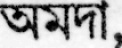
অমদা,
